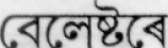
বেলেষ্টৰে
